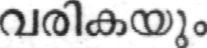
വരികയും
